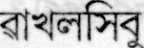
ৱাখলসিবু
